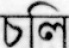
চলি
